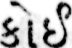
કોઈ
